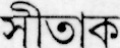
সীতাক
